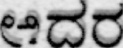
ಅದರ
